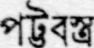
পট্টবস্ত্র
